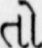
તો
